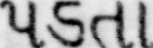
પડતા
